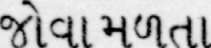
જોવામળતા
